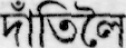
দাঁতিলৈ
